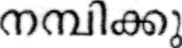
നമ്പിക്കു
